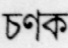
চণক
